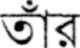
তাঁর
